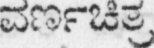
ವರ್ಣಚಿತ್ರ
